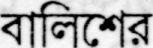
বালিশের
